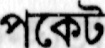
পকেট
